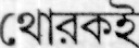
থোরকই
